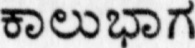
ಕಾಲುಭಾಗ
